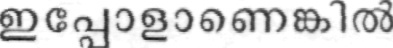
ഇപ്പോളാണെങ്കില്‍
